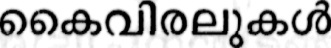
കൈവിരലുകള്‍
